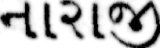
નારાજી
